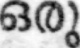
ഒരു
